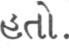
હતો.
